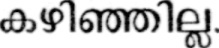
കഴിഞ്ഞില്ല.
